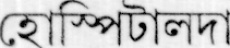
হোস্পিটালদা
